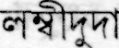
লম্বীদুদা
